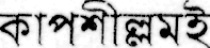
কাপশীল্লকই
